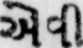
એવી
